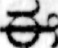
ಈ
